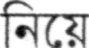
নিয়ে
